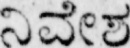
ನಿವೇಶ
